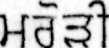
ਮਰੋੜੀ
